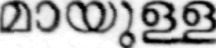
മായുള്ള
